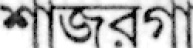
শাজরগা
